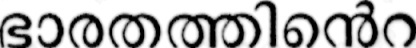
ഭാരതത്തിന്റെ
